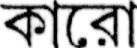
কারো
